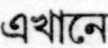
এখানে
